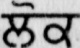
ਲੋਕ
